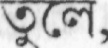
তুলে,
